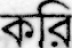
করি
